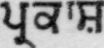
ਪ੍ਰਕਾਸ਼
